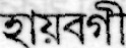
হায়বগী
